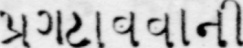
પ્રગટાવવાની
